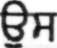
ਉਸ
